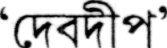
‘দেবদীপ’
